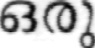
ഒരു
